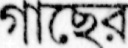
গাছের
